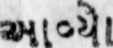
આવ્યો
